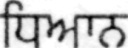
ਧਿਆਨ
